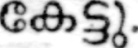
കേട്ടു.
